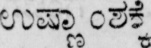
ಉಷ್ಣಾಂಶಕ್ಕೆ
